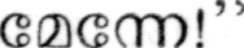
മേന്നേ!"
